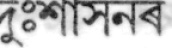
দুঃশাসনৰ
